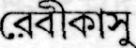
রেবীকাসু
